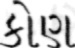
કોણ
